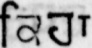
ਕਿਹਾ
